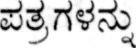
ಪತ್ರಗಳನ್ನು
